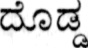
ದೊಡ್ಡ
